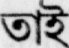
তাই
